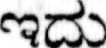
ಇದು
